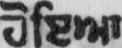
ਹੋਇਆ
